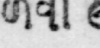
મેળવી
